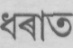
ধৰাত
